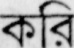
করি
